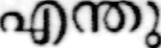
എന്തു
